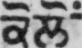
ਕੋਲੋਂ
